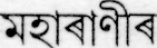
মহাৰাণীৰ
